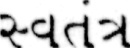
સ્વતંત્ર
